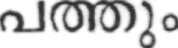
പത്തും
